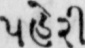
પહેરી
